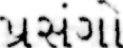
પ્રસંગો
